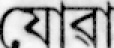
যোৱা
